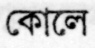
কোলে
